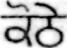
ਕੋਠੇ
